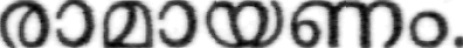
രാമായണം.
